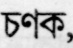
চণক,
